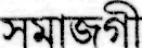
সমাজগী
